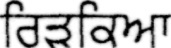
ਰਿੜਕਿਆ
